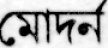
মোর্দন
